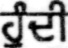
ਹੁੰਦੀ
